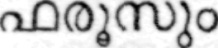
ഫരൂസും
